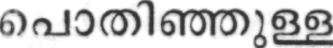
പൊതിഞ്ഞുള്ള
